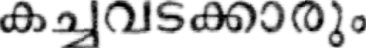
കച്ചവടക്കാരും
